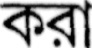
করা
